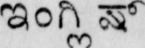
ಇಂಗ್ಲಿಷ್
